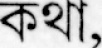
কথা,
